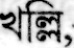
খল্লি,
